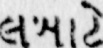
લબાટે
